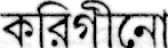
করিগীনো
